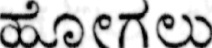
ಹೋಗಲು
